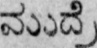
ಮುದ್ರೆ
